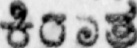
ಕಿರಾತ
